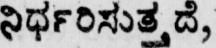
ನಿರ್ಧರಿಸುತ್ತದೆ,
